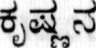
ಕೃಷ್ಣನ
